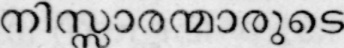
നിസ്സാരന്മാരുടെ
